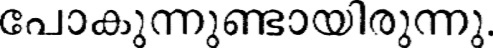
പോകുന്നുണ്ടായിരുന്നു.
